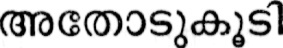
അതോടുകൂടി
